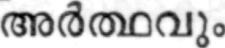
അര്‍ത്ഥവും
